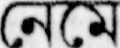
নেমে
